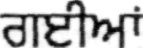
ਗਈਆਂ
